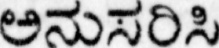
ಅನುಸರಿಸಿ
